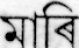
মাৰি
